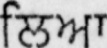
ਲਿਆ
